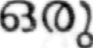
ഒരു
